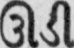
ઊડી
